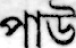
পাউ
